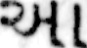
આ
